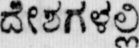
ದೇಶಗಳಲ್ಲಿ
